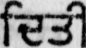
ਦਿਤੀ
